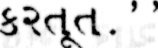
કરતૂત."
